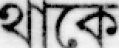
থাকে
